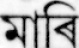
মাৰি
